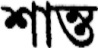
শান্ত
